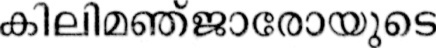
കിലിമഞ്ജാരോയുടെ
